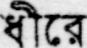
ধীরে
